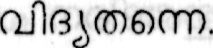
വിദ്യതന്നെ.
